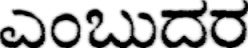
ಎಂಬುದರ
